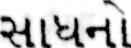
સાધનો
